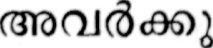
അവര്‍ക്കു
